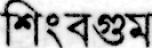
শিংবগুং
